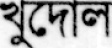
খুদোল
